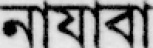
নাযাবা
